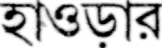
হাওড়ার
